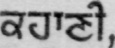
ਕਹਾਣੀ,
